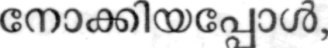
നോക്കിയപ്പോള്‍,
